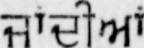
ਜਾਂਦੀਆਂ
